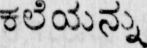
ಕಲೆಯನ್ನು
